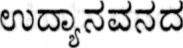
ಉದ್ಯಾನವನದ
